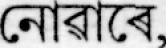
নোৱাৰে,
